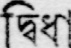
দ্বিধা
